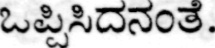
ಒಪ್ಪಿಸಿದನಂತೆ.
